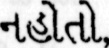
નહોતો,
